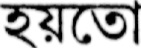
হয়তো
